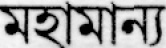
মহামান্য
